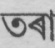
তৰা
